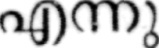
എന്നു
